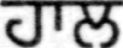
ਹਾਲ
